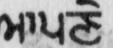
ਆਪਣੇ
